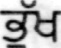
ਭੁੱਖ
